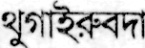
থুগাইরুবদা
